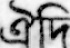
ঐদি
